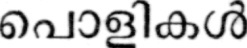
പൊളികള്‍
